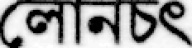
লোনচৎ
